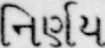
નિર્ણય
